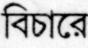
বিচারে
